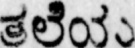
ತಲೆಯ
